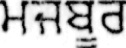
ਮਜਬੂਰ
